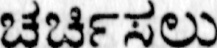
ಚರ್ಚಿಸಲು
